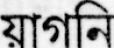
য়াগনি
